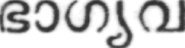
ഭാഗ്യവ
